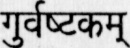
गुर्वष्टकम्
